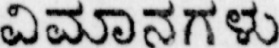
ವಿಮಾನಗಳು
